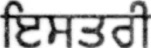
ਇਸਤਰੀ
